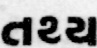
તથ્ય
